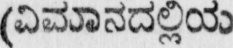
(ವಿಮಾನದಲ್ಲಿಯ
